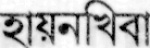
হায়নখিবা
